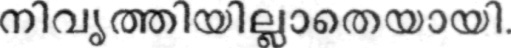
നിവൃത്തിയില്ലാതെയായി.
